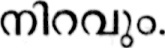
നിറവും.
